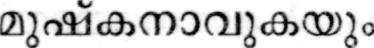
മുഷ്കനാവുകയും
